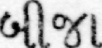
બીજા
